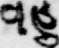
વહુ
